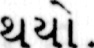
થયો.
